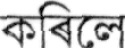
কৰিলে
